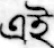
এই
